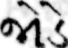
જોડે
